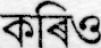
কৰিও
